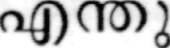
എന്തു
